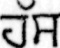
ਹੱਸ
